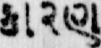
કારણ
